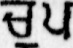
ਚੁਪ
